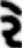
રે
